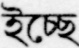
ইচ্ছে
